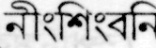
নীংশিংবনি
